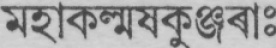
মহাকল্মষকুঞ্জৰাঃ
